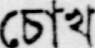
চোখ
